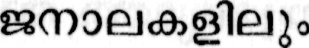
ജനാലകളിലും
